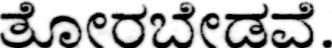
ತೋರಬೇಡವೆ.
